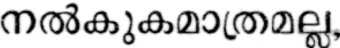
നല്‍കുകമാത്രമല്ല,
